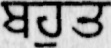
ਬਹੁਤ
